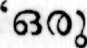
'ഒരു
